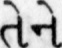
તેને
